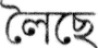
লৈছে
